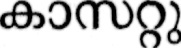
കാസറ്റു
